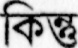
কিন্তু
